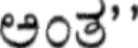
ಅಂತ"
